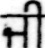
ਜੀ
